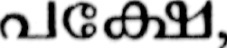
പക്ഷേ,
